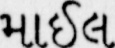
માઈલ
